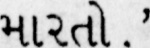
મારતો.'
